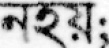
নহয়;
